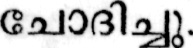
ചോദിച്ചു.
